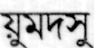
য়ুমদসু
